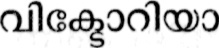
വിക്ടോറിയാ
